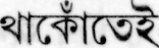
থাকোঁতেই
